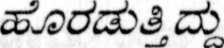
ಹೊರಡುತ್ತಿದ್ದು
